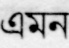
এমন
